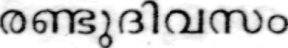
രണ്ടുദിവസം
